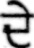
ਦੇ
